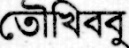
তৌখিববু
